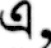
এ,
